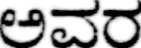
ಅವರ
